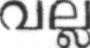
വല്ല
